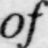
of
